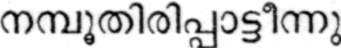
നമ്പൂതിരിപ്പാട്ടീന്നു
